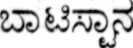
ಬಾಟಿಸ್ಟಾನ
